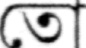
তো
